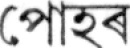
পোহৰ
